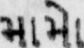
મામો
